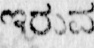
ಇರುವ
